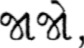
જાજો,
